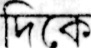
দিকে
